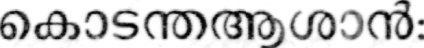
കൊടന്തആശാന്‍:
